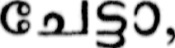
ചേട്ടാ,
